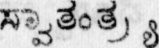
ಸ್ವಾತಂತ್ರ್ಯ
